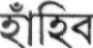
হাঁহিব
